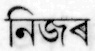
নিজৰ
